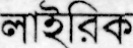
লাইরিক
